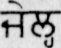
ਜੇਲ੍ਹ
